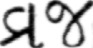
વ્રજ
